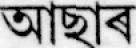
আছাৰ
